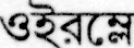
ওইরম্লে
